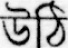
উঠি
